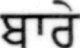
ਬਾਰੇ
